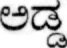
ಅಡ್ಡ
